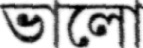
ভালো
